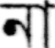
না
